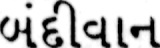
બંદીવાન
